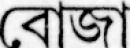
বোজা
